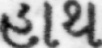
હાથ
